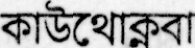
কাউথোক্নবা
